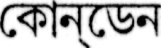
কোন্ডেন
